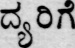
ದ್ಯರಿಗೆ
